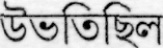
উভতিছিল
